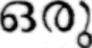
ഒരു
